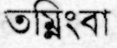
তম্নিংবা
